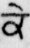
ਕੇ
